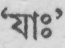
'যাঃ'
